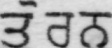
ਤੋਰਨ
